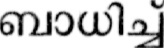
ബാധിച്ച്
